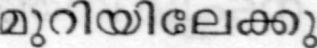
മുറിയിലേക്കു
